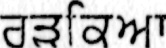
ਰੜਕਿਆ
